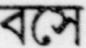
বসে
